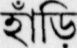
হাঁড়ি
